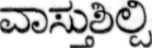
ವಾಸ್ತುಶಿಲ್ಪಿ
